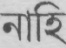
নাহি
